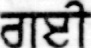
ਗਈ
